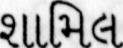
શામિલ
